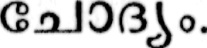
ചോദ്യം.
